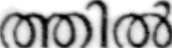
ത്തില്‍
